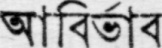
আবির্ভাব
